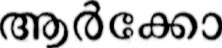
ആര്‍ക്കോ
